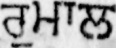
ਰੁਮਾਲ
